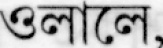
ওলালে,
